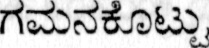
ಗಮನಕೊಟ್ಟು
